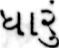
ધારું
